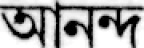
আনন্দ
